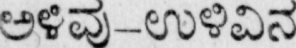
ಅಳಿವು-ಉಳಿವಿನ
